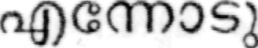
എന്നോടു
